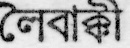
লৈবাক্কী
